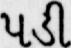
પડી
